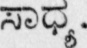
ಸಾಧ್ಯ.
